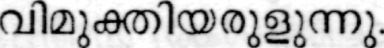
വിമുക്തിയരുളുന്നു.
